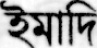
ইমাদি
